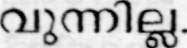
വുന്നില്ല.
